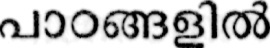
പാഠങ്ങളില്‍
